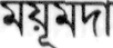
ময়ূমদা
